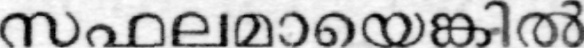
സഫലമായെങ്കില്‍
